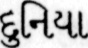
દુનિયા
